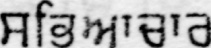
ਸਭਿਆਚਾਰ
